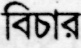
বিচার
